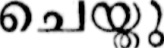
ചെയ്തു
